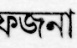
ফজনা
